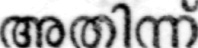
അതിന്ന്
